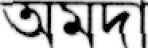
অমদা
